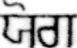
ਯੋਗ
